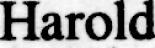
Harold
